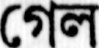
গেল
